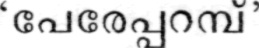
'പേരേപ്പറമ്പ്’
